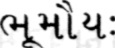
ભૂમૌયઃ
